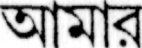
আমার
